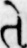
તે
